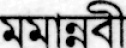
মমান্নবী
